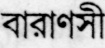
বারাণসী
